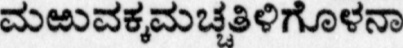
ಮಱುವಕ್ಕಮಚ್ಚತಿಳಿಗೊಳನಾ
